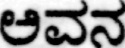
ಅವನ
